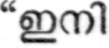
“ഇനി
